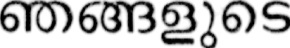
ഞങ്ങളുടെ
